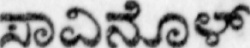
ಸಾವಿನೊಳ್
